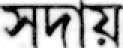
সদায়
